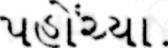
પહોંચ્યા.
